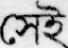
সেই
